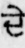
ਦੇ
